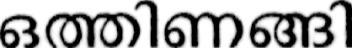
ഒത്തിണങ്ങി
